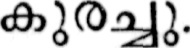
കുരച്ചു.
